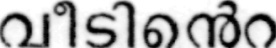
വീടിന്റെ
